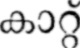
കാറ്റ്
